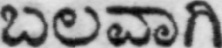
ಬಲವಾಗಿ
